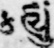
કહ્યું
